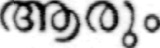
ആരും
